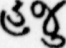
હજુ
